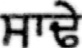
ਸਾਢੇ
